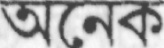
অনেক
